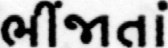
ભીંજાતાં
